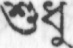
শুধু
